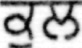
ਕੁਲ
